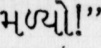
મળ્યો!"
